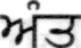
ਅੰਤ
